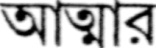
আত্মার
